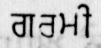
ਗਰਮੀ
